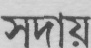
সদায়
